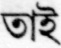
তাই
